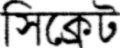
সিক্রেট
